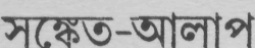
সঙ্কেত-আলাপ
